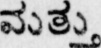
ಮತ್ತು
